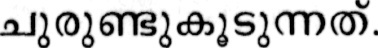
ചുരുണ്ടുകൂടുന്നത്.
